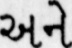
અને
